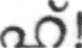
ഹ്!
